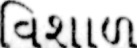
વિશાળ
